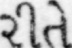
રીતે
